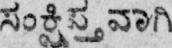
ಸಂಕ್ಷಿಪ್ತವಾಗಿ
